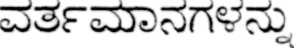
ವರ್ತಮಾನಗಳನ್ನು
